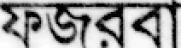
ফজরবা
